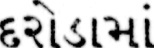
દરોડામાં
